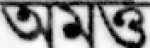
অমত্ত
